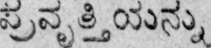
ಪ್ರವೃತ್ತಿಯನ್ನು
